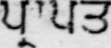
ਪ੍ਰਾਪਤ
